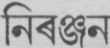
নিৰঞ্জন
